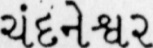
ચંદનેશ્વર
